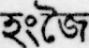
হংজৈ
